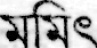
মমিৎ
